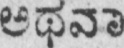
ಅಥವಾ
